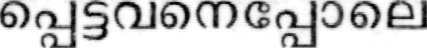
പ്പെട്ടവനെപ്പോലെ
